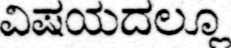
ವಿಷಯದಲ್ಲೂ
